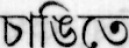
চাঙিতে
